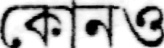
কোনও
